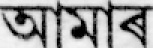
আমাৰ
